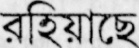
রহিয়াছে
